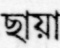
ছায়া
